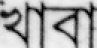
খাবা
